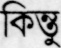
কিন্তু
